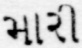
મારી
